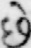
છે
